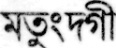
মতুংদগী
